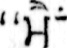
''ਮੈਂ
